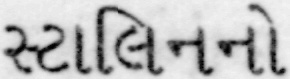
સ્ટાલિનનો
